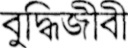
বুদ্ধিজীবী
